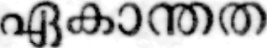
ഏകാന്തത
